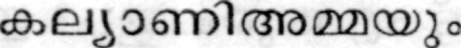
കല്യാണിഅമ്മയും
